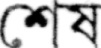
শেষ
